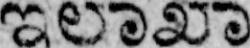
ಇಲಾಖಾ
